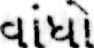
વાંધો
